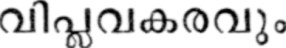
വിപ്ലവകരവും
